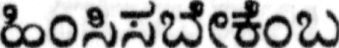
ಹಿಂಸಿಸಬೇಕೆಂಬ
